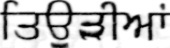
ਤਿਉੜੀਆਂ
